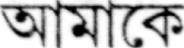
আমাকে
